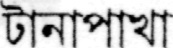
টানাপাখা
